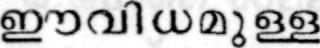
ഈവിധമുള്ള
